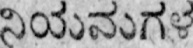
ನಿಯಮಗಳ
